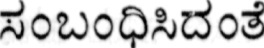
ಸಂಬಂಧಿಸಿದಂತೆ
